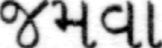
જમવા
